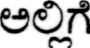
ಅಲ್ಲಿಗೆ
